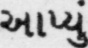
આપ્યું
